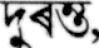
দুৰন্ত,
